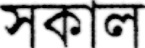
সকাল
